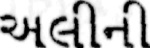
અલીની
